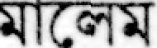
মালেম
